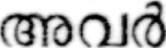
അവര്‍
